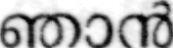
ഞാന്‍
